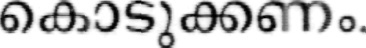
കൊടുക്കണം.
